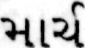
માર્ચ
